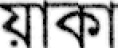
য়াকা
